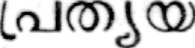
പ്രത്യയ
